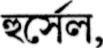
হুর্সেল,
